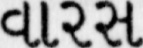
વારસ
